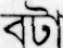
বটা
